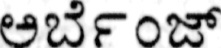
ಅರ್ಬೆಂಜ್
